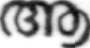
ആ
